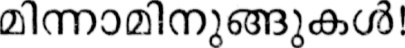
മിന്നാമിനുങ്ങുകള്‍!
